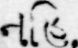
નહિ.
